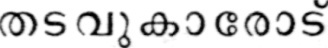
തടവുകാരോട്
